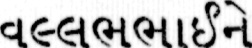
વલ્લભભાઈને
